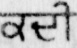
ਕਦੀ
